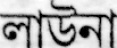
লাউনা
